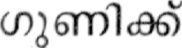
ഗുണിക്ക്
